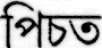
পিচত
